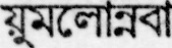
য়ুমলোন্নবা
